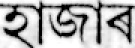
হাজাৰ
